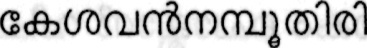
കേശവന്‍നമ്പൂതിരി
